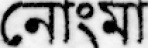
নোংমা
